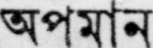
অপমান
